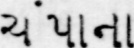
ચંપાના
